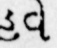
હવે
